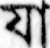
যা
